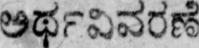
ಅರ್ಥವಿವರಣೆ
